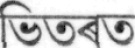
ভিতৰত
